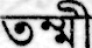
তম্মী
